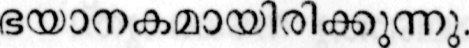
ഭയാനകമായിരിക്കുന്നു.
